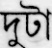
দুটা
